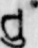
તું
